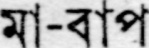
মা-বাপ
